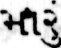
મારું
